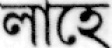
লাহে
